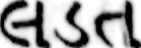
લડત
